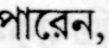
পারেন,
